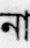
না
